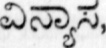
ವಿನ್ಯಾಸ,
